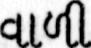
વાળી
